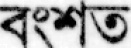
বংশত
